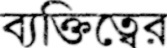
ব্যক্তিত্বের
